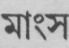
মাংস
